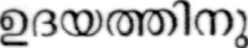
ഉദയത്തിനു
